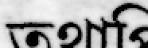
তথাপি
